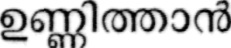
ഉണ്ണിത്താന്‍
